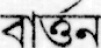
বার্ত্তন
